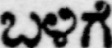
ಬಳಿಗೆ
